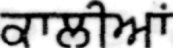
ਕਾਲੀਆਂ
